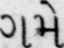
ગમે
